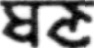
ਬਣ
